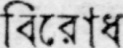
বিরোধ
